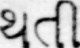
થતી
